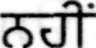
ਨਹੀਂ
